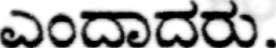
ಎಂದಾದರು.
